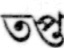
তপ্ত
